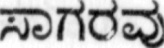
ಸಾಗರವು
